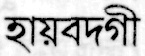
হায়বদগী
